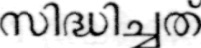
സിദ്ധിച്ചത്
